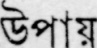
উপায়
